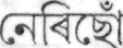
নেৰিছোঁ
